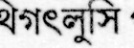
থিগৎলুসি
